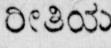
ರೀತಿಯ
